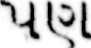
પણ
